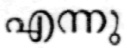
എന്നു
